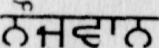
ਨੌਜਵਾਨ
